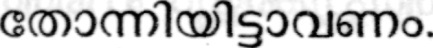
തോന്നിയിട്ടാവണം.
